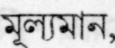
মূল্যমান,
